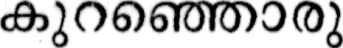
കുറഞ്ഞൊരു
